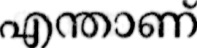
എന്താണ്
